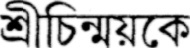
শ্রীচিন্ময়কে
